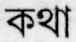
কথা
